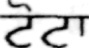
ਟੋਟਾ
